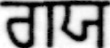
ਗਯ
